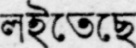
লইতেছে
